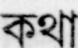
কথা
